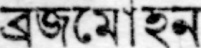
ব্রজমোহন
